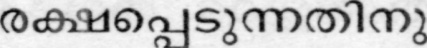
രക്ഷപ്പെടുന്നതിനു
